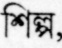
শিল্প,
